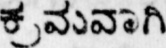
ಕ್ರಮವಾಗಿ
